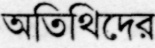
অতিথিদের
